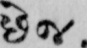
છેજ.
